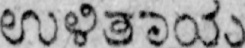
ಉಳಿತಾಯ
